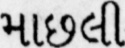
માછલી
